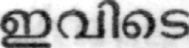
ഇവിടെ
